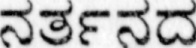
ನರ್ತನದ
